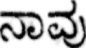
ನಾವು
